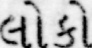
લોકો
